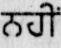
ਨਹੀਂ
